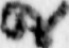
જ
